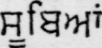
ਸੂਬਿਆਂ
